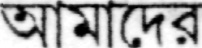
আমাদের
